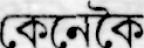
কেনেকৈ
